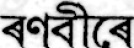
ৰণবীৰে
